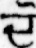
ਦੋ
